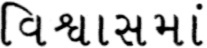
વિશ્વાસમાં
